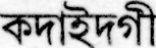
কদাইদগী
